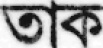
তাক
